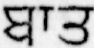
ਬਾਤ
